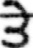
ਤੇ
